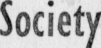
Society
